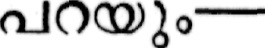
പറയും-
